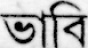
ভাবি
